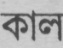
কাল
